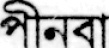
পীনবা
